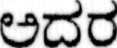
ಅದರ
